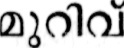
മുറിവ്
